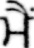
ਮੈਂ
